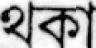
থকা
